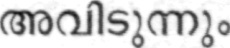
അവിടുന്നും
